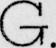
G.
